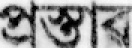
প্রস্তাৱ
